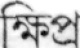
ক্ষিপ্র
